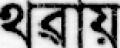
থৱায়
